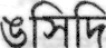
ঙসিদি
